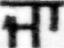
ਜਾ
